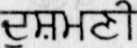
ਦੁਸ਼ਮਣੀ
